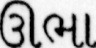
ઊભા
